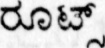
ರೂಟ್ಸ್
